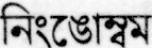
নিংঙোম্বম
